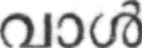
വാള്‍
